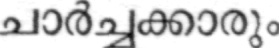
ചാര്‍ച്ചക്കാരും
